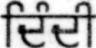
ਦਿੰਦੀ
